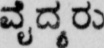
ವೈದ್ಯರು
